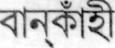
বান্‌কাঁহী
